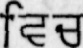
ਵਿਚ
